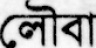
লৌবা
